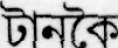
টানকৈ
